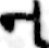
ન
